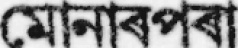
মোনাৰপৰা
